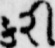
કરી
